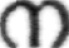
ന
